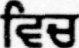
ਵਿਚ
